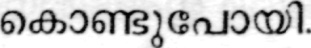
കൊണ്ടുപോയി.
